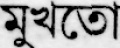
মুখতো
